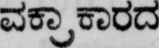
ವಕ್ರಾಕಾರದ
